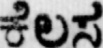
ಕೆಲಸ
